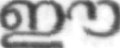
ഈ
